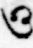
ও
